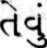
તેવું
